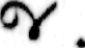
જ.
